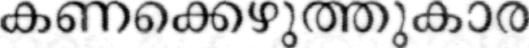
കണക്കെഴുത്തുകാര
